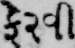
ફેરવી
